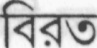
বিরত
